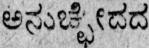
ಅನುಚ್ಛೇದದ
